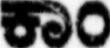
ಕಾ೦
